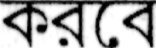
করবে
